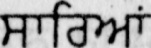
ਸਾਰਿਆਂ
